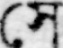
সে
